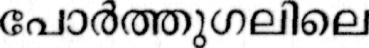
പോര്‍ത്തുഗലിലെ
